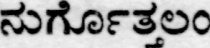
ನುರ್ಗೊತ್ತಲಂ
